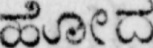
ಹೋದ
